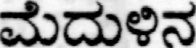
ಮೆದುಳಿನ
